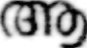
ആ
